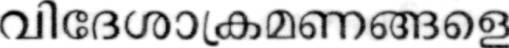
വിദേശാക്രമണങ്ങളെ
